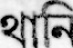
থানি
